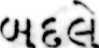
બદલે
